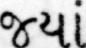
જ્યાં
